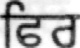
ਫਿਰ
